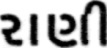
રાણી
